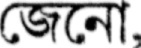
জেনো,
